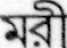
মরী
